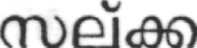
സല്ക്ക
